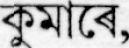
কুমাৰে,
